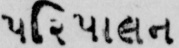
પરિપાલન
